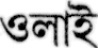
ওলাই
